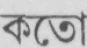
কতো
